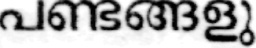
പണ്ടങ്ങളു
